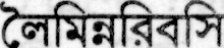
লৈমিন্নরিবসি
